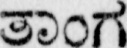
ತಾಂಗ
